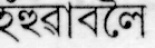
হঁহুৱাবলৈ
